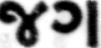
જગ
